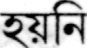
হয়নি
